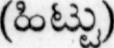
(ಹಿಟ್ಟು)
